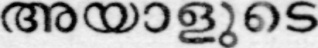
അയാളുടെ
